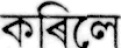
কৰিলে
